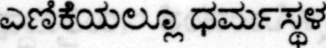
ಎಣಿಕೆಯಲ್ಲೂಧರ್ಮಸ್ಥಳ
